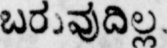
ಬರುವುದಿಲ್ಲ.
